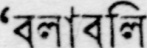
‘বলাবলি
